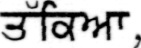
ਤੱਕਿਆ,
